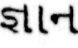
જ્ઞાન
